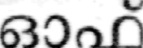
ഓഫ്
